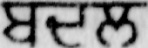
ਬਦਲ
